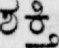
ಶಕ್ತಿ
